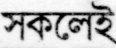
সকলেই
